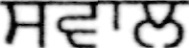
ਸਵਾਲ
